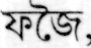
ফজৈ,
